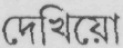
দেখিয়ো
